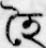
হৈ
